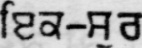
ਇਕ-ਸੁਰ
